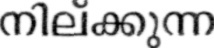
നില്ക്കുന്ന
